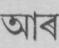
আৰ
